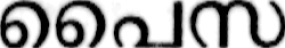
പൈസ
